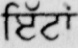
ਇੱਟਾਂ
